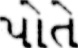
પોતે
